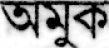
অমুক
